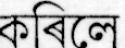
কৰিলে
